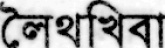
লৈথখিবা
